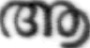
ആ
